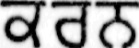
ਕਰਨ
